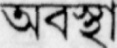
অবস্থা
